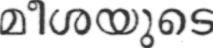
മീശയുടെ
